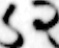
ડર
